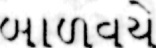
બાળવયે
